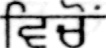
ਵਿਚੋਂ
